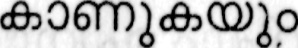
കാണുകയും
